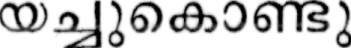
യച്ചുകൊണ്ടു
